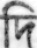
দি
